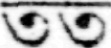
তত
